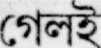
গেলই
